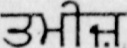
ਤਮੀਜ਼
